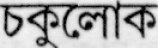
চকুলোক
